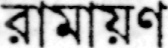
রামায়ণ
